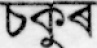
চকুৰ
